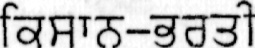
ਕਿਸਾਨ-ਭਰਤੀ
